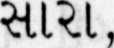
સારા,
